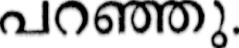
പറഞ്ഞു.
